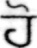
ਹੋ
